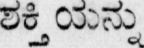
ಶಕ್ತಿಯನ್ನು
